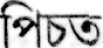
পিচত
